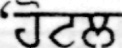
'ਹੋਟਲ
